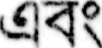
এবং
